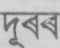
দূৰৰ
